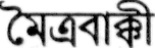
মৈত্রবাক্কী
